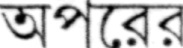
অপরের
